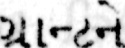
ગ્રાન્ટને
